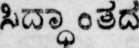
ಸಿದ್ಧಾಂತದ
